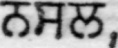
ਨਸਲ,
